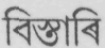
বিস্তাৰি
